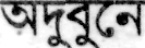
অদুবুনে
